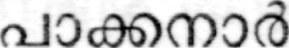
പാക്കനാര്‍
